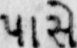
પાસે
